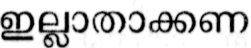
ഇല്ലാതാക്കണ
